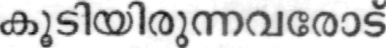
കൂടിയിരുന്നവരോട്
